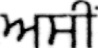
ਅਸੀਂ
